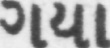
ગયા
